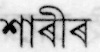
শাৰীৰ
